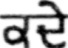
ਕਦੇ
